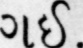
ગઈ.
